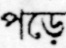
পড়ে
